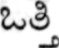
ಒತ್ತಿ
